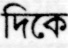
দিকে
